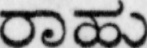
ರಾಹು
